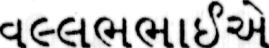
વલ્લભભાઈએ
